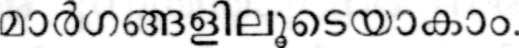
മാര്‍ഗങ്ങളിലൂടെയാകാം.
